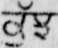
ਕੁੱਝ
